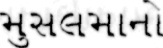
મુસલમાનો
